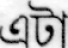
এটা
